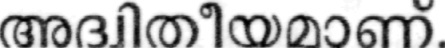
അദ്വിതീയമാണ്.
